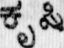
ಕೃಷಿ
